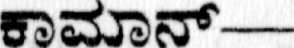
ಕಾಮಾನ್-
